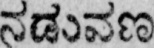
ನಡುವಣ
